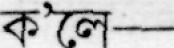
ক'লে-
